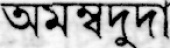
অমম্বদুদা
